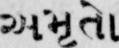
અમૃતો
